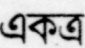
একত্র
